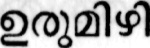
ഉരുമിഴി
